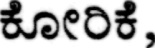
ಕೋರಿಕೆ,
